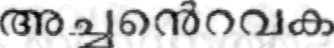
അച്ചന്റെവക
